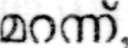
മറന്ന്,
